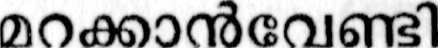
മറക്കാന്‍വേണ്ടി
